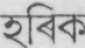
হৰিক
